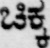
ಚಿಕ್ಕ
